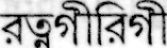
রত্নগীরিগী
